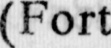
(Fort
